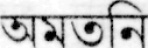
অমতনি
